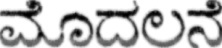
ಮೊದಲನೆ
